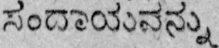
ಸಂದಾಯವನ್ನು
